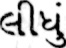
લીધું
